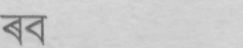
ৰব
